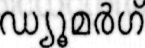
ഡ്യൂമര്‍ഗ്
